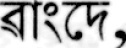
ৱাংদে,
